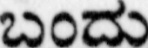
ಬಂದು
